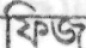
ফিজ
